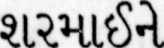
શરમાઈને
